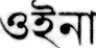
ওইনা
